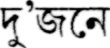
দু’জনে
